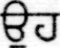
ਉਹ
